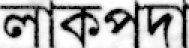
লাকপদা
